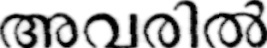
അവരില്‍
